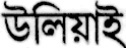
উলিয়াই
